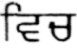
ਵਿਚ
